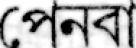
পেনবা
